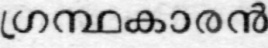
ഗ്രന്ഥകാരന്‍
